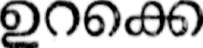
ഉറക്കെ
